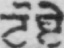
ਟੋਏ
